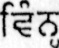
ਵਿੰਨ੍ਹ
